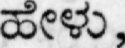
ಹೇಳು,
